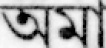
অমা
